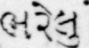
ભરેલું
